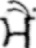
ਮੈਂ
